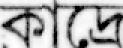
কাদ্রে
